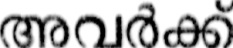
അവര്‍ക്ക്
